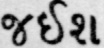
જઈશ
